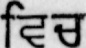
ਵਿਚ
